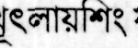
খূৎলায়শিং
